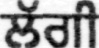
ਲੱਗੀ
